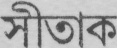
সীতাক
